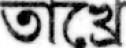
তাখ্রে
